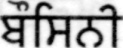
ਬੌਸਿਨੀ
